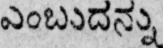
ಎಂಬುದನ್ನು
